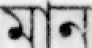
মান
